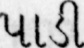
પાડી
